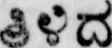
ತಿಳಿದ
